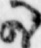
જે
